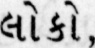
લોકો,
